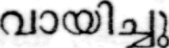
വായിച്ചു
